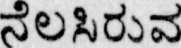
ನೆಲಸಿರುವ
